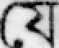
যে
